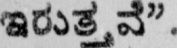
ಇರುತ್ತವೆ”.
